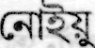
নোইয়ু
